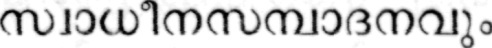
സ്വാധീനസമ്പാദനവും
